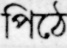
পিঠে
